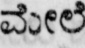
ಮೇಲೆ
